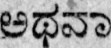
ಅಥವಾ
